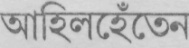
আহিলহেঁতেন
